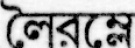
লৈরম্লে
